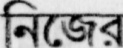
নিজের
